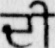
ਦੀ
